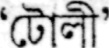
‘টোলী’
